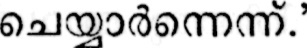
ചെയ്യാര്‍ന്നെന്ന്.’
